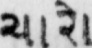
ચારો
